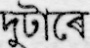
দুটাৰে
